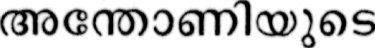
അന്തോണിയുടെ
